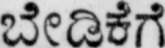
ಬೇಡಿಕೆಗೆ
